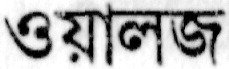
ওয়ালজ
